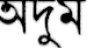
অদুম
